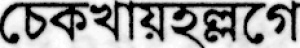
চেকখায়হল্লগে
